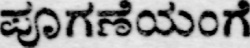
ಪೂಗಣೆಯಂಗೆ
